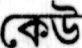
কেউ
